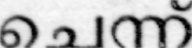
ചെന്ന്
